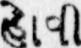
હોવી
